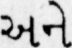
અને
